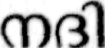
നദി
